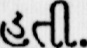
હતી.
